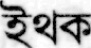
ইথক
